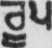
ਰੂਪ
